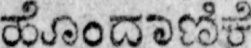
ಹೊಂದಾಣಿಕೆ
